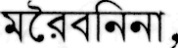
মরৈবনিনা,
